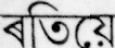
ৰতিয়ে
